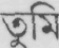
তুমি
